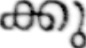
ക്കു
